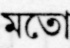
মতো
